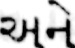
અને
